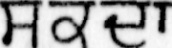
ਸਕਦਾ
